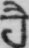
ਹੈ
